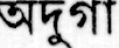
অদুগা
